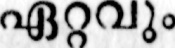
ഏറ്റവും
